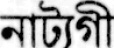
নাট্যগী
